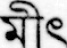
মীৎ
